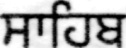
ਸਾਹਿਬ
